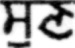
ਸੁਣ
